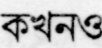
কখনও
